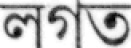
লগত
